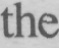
the
